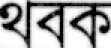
থবক
